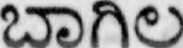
ಬಾಗಿಲ
